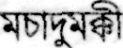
মচাদুমক্কী
